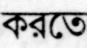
করতে
